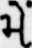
મેં
